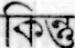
কিন্তু
